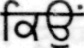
ਕਿਉਂ
